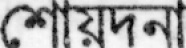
শোয়দনা
